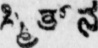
ಸ್ಮಿತ್ನ
